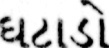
ઘટાડો
